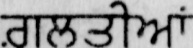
ਗ਼ਲਤੀਆਂ
